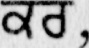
ਕਰ,
